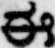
ಈ
